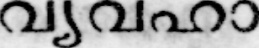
വ്യവഹാ
